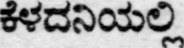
ಕೆಳದನಿಯಲ್ಲಿ
